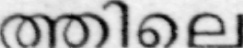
ത്തിലെ
